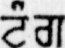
ਟੰਗ
